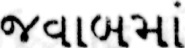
જવાબમાં
